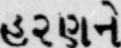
હરણને
